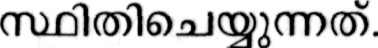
സ്ഥിതിചെയ്യുന്നത്.
